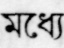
মধ্যে
